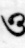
ও
